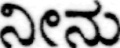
ನೀನು
